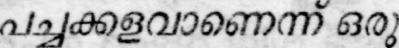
പച്ചക്കളവാണെന്ന്ഒരു
